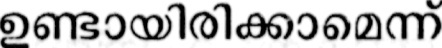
ഉണ്ടായിരിക്കാമെന്ന്
